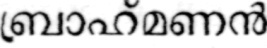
ബ്രാഹ്മണന്‍
